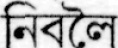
নিবলৈ
